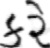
કરે
